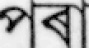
পৰা
